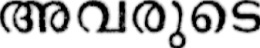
അവരുടെ
